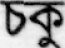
চকু
